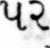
પર
